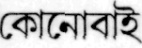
কোনোবাই
